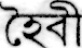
হৈবী
